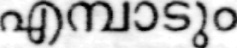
എമ്പാടും
